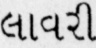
લાવરી
